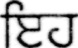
ਇਹ
